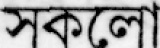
সকলো
